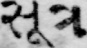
સૂત્ર
